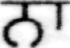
ਨਾ
